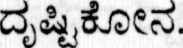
ದೃಷ್ಟಿಕೋನ.
